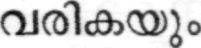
വരികയും
